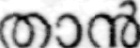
താന്‍
